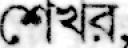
শেখর,
